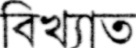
বিখ্যাত
